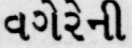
વગેરેની
